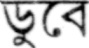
ডুবে
